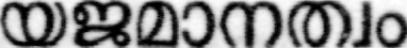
യജമാനത്വം
